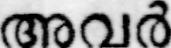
അവര്‍
